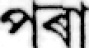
পৰা
